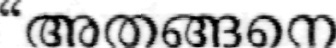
“അതങ്ങനെ
